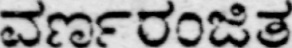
ವರ್ಣರಂಜಿತ
